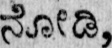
ನೋಡಿ,
